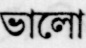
ভালো
